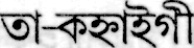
তা-কহ্নাইগী
